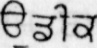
ਉਡੀਕ
